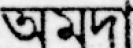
অমদা
